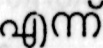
എന്ന്
